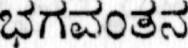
ಭಗವಂತನ
